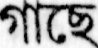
গাছে
